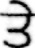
ਤੇ
